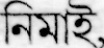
নিমাই,
